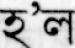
হ'ল
